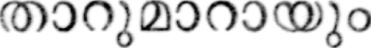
താറുമാറായും
